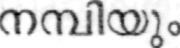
നമ്പിയും
